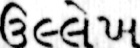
ઉલ્લેખ
